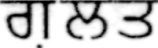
ਗ਼ਲਤ
